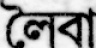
লৈবা
